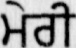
ਮੇਰੀ
